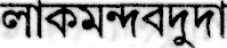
লাকমন্দবদুদা
